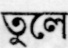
তুলে
